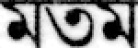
মতম
